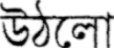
উঠলো
